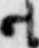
ન
